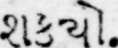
શક્યો.
